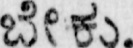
ಬೇಕು.
